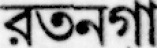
রতনগা
